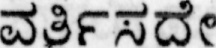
ವರ್ತಿಸದೇ
